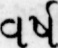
વર્ષ
